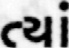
ત્યાં
